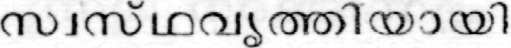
സ്വസ്ഥവൃത്തിയായി
